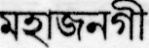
মহাজনগী
